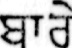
ਬਾਰੇ
